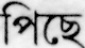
পিছে
